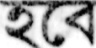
হবে
